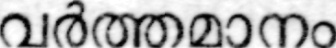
വര്‍ത്തമാനം
